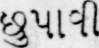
છુપાવી
